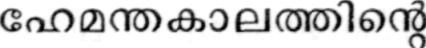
ഹേമന്തകാലത്തിന്റെ
